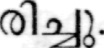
രിച്ചു.
